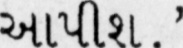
આપીશ.'
